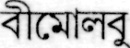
বীমোলবু
